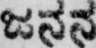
ಜನನ
